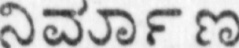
ನಿರ್ಮಾಣ
